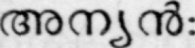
അന്യന്‍:
